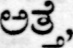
ಅತ್ತೆ,
